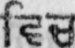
ਵਿਚ
